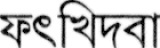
ফৎখিদবা
